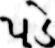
પડે
